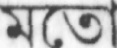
মতো
